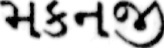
મકનજી
